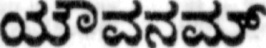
ಯೌವನಮ್
